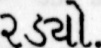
રડ્યો.
